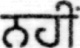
ਨਹੀਂ
